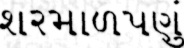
શરમાળપણું
